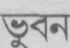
ভুবন
